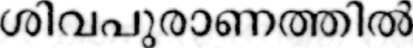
ശിവപുരാണത്തില്‍
